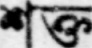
শক্ত
